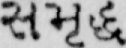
સમૃદ્ધ
